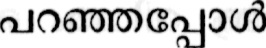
പറഞ്ഞപ്പോള്‍
